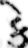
કે
